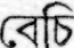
বেচি
